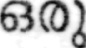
ഒരു
